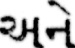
અને
